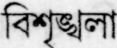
বিশৃঙ্খলা
